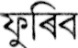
ফুৰিব
